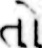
તો
